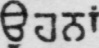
ਉਹਨਾਂ
